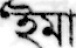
‘ইমা
